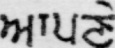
ਆਪਣੇ
